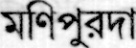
মণিপুরদা
